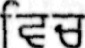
ਵਿਚ
